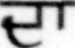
ਦਾ
